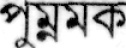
পুম্নমক
